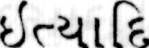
ઈત્યાદિ
